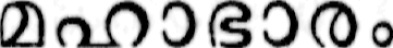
മഹാഭാരം
